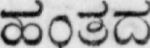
ಹಂತದ
